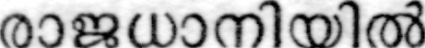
രാജധാനിയില്‍
